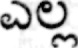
ಎಲ್ಲ
